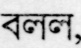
বলল,
